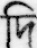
দি
